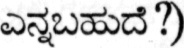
ಎನ್ನಬಹುದೆ?)ಚ
